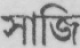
সাজি
